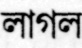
লাগল
